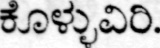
ಕೊಳ್ಳುವಿರಿ.
